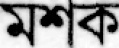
মশক
